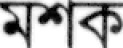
মশক
